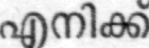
എനിക്ക്
